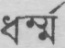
ধৰ্ম্ম
